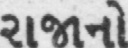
રાજાનો
